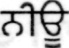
ਨੀਊ
